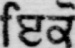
ਇਕੋ
